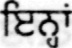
ਇਨ੍ਹਾਂ
